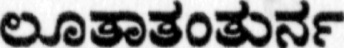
ಲೂತಾತಂತುರ್ನ
